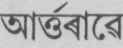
আৰ্ত্তৰাৱে
